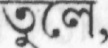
তুলে,
